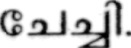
ചേച്ചി.
